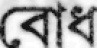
বোধ
